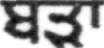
ਬੜਾ
